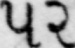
પર
